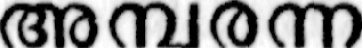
അമ്പരന്ന
